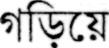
গড়িয়ে
